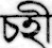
চহী
